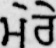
ਮੇਰੇ
